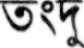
তংদু
